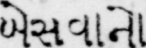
બેસવાનો
